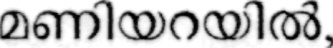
മണിയറയില്‍,
